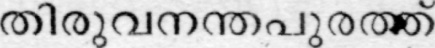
തിരുവനന്തപുരത്ത്
